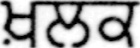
ਖ਼ਲਕ
